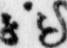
કંઈ
